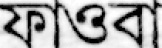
ফাওবা
